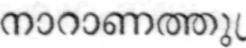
നാറാണത്തു
